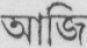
আজি
